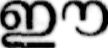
ഈ
